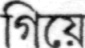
গিয়ে
